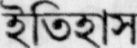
ইতিহাস
